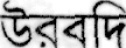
উরবদি
